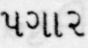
પગાર
